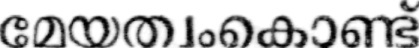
മേയത്വംകൊണ്ട്
